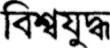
বিশ্বযুদ্ধ
